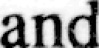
and
